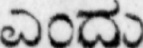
ಎಂದು
